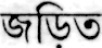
জড়িত
